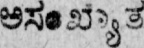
ಅಸಂಖ್ಯಾತ
